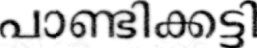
പാണ്ടിക്കട്ടി
